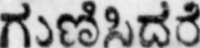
ಗುಣಿಸಿದರೆ
